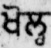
ਖੋਲ੍ਹ
